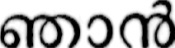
ഞാന്‍
